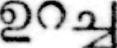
ഉറച്ച
